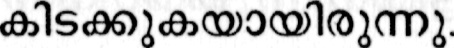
കിടക്കുകയായിരുന്നു.
